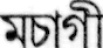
মচাগী
